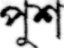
পুশ
